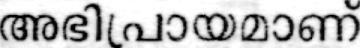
അഭിപ്രായമാണ്
